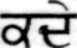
ਕਦੇ
